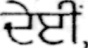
ਦੇਈਂ,
